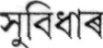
সুবিধাৰ
